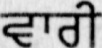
ਵਾਰੀ
